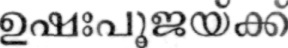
ഉഷഃപൂജയ്ക്ക്
